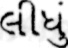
લીધું
